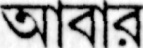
আবার
